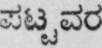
ಪಟ್ಟವರ
